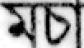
মচা
